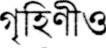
গৃহিণীও
